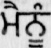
ਮੈਨੂੰ
